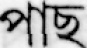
পাছ
